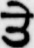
ਤੇ
